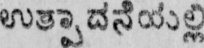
ಉತ್ಪಾದನೆಯಲ್ಲಿ
